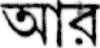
আর
